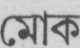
মোক
